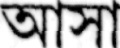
আসা
